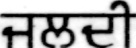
ਜਲਦੀ
